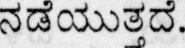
ನಡೆಯುತ್ತದೆ.
